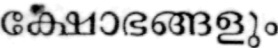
ക്ഷോഭങ്ങളും
